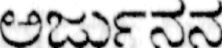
ಅರ್ಜುನನ
